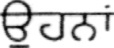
ਉਹਨਾਂ
